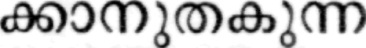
ക്കാനുതകുന്ന
